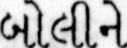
બોલીને
